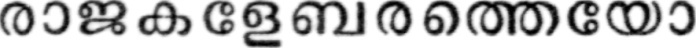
രാജകളേബരത്തെയോ
